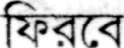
ফিরবে
